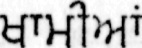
ਖਾਮੀਆਂ
